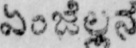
ಏಂಜೆಲ್ಲನ
